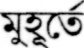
মুহূর্তে
